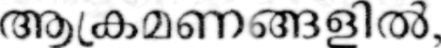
ആക്രമണങ്ങളില്‍,
